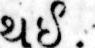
થઈ.
